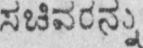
ಸಚಿವರನ್ನು
